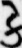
કે
